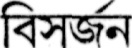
বিসর্জন
